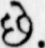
છ.
